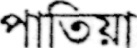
পাতিয়া
